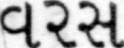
વરસ
